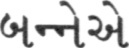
બન્નેએ
